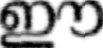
ഈ
